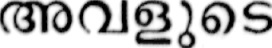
അവളുടെ
